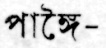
পাঙ্গৈ-
